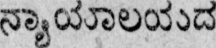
ನ್ಯಾಯಾಲಯದ
